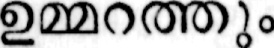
ഉമ്മറത്തും
